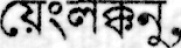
য়েলক্কনু,
